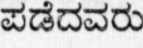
ಪಡೆದವರು
